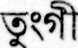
তুংগী
